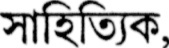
সাহিত্যিক,
